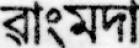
ৱাংমদা
